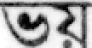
ভয়
